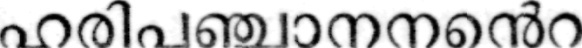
ഹരിപഞ്ചാനനന്റെ
